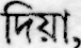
দিয়া,
